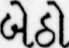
બેઠો
